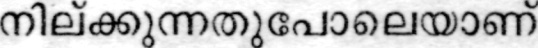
നില്ക്കുന്നതുപോലെയാണ്
